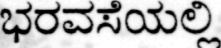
ಭರವಸೆಯಲ್ಲಿ
